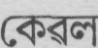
কেৱল
